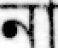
না
